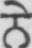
ਨੇ
